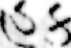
હક
